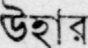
উহার
